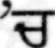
'ਚ
